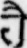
ਹੈ
